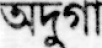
অদুগা
